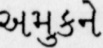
અમુકને
